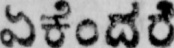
ಏಕೆಂದರೆ
